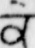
ਕੇ
